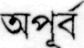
অপূর্ব
